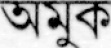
অমুক
